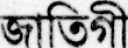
জাতিগী
